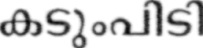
കടുംപിടി
